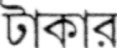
টাকার
